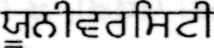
ਯੂਨੀਵਰਸਿਟੀ
